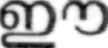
ഈ
